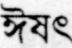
ঈষত্
